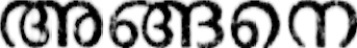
അങ്ങനെ
